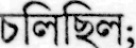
চলিছিল;
